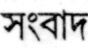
সংবাদ
